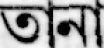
তানা
